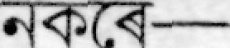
নকৰে-
